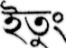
ইতুং
